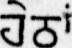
ਹੇਠਾਂ
